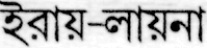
ইরায়-লায়না
